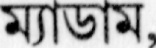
ম্যাডাম,
